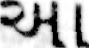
આ
